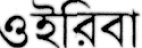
ওইরিবা
